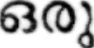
ഒരു
